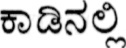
ಕಾಡಿನಲ್ಲಿ
